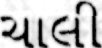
ચાલી
